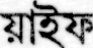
য়াইফ
